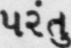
પરંતુ
